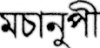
মচানুপী
